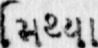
મિથ્યા
